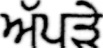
ਅੱਪੜੇ
